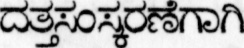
ದತ್ತಸಂಸ್ಕರಣೆಗಾಗಿ
